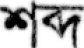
শব্দ
